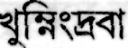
খুম্নিংদ্রবা
